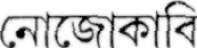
নোজোকাবি
